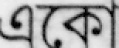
একো
